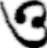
ও
